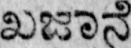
ಖಜಾನೆ
